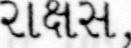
રાક્ષસ,
